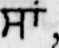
ਸਾਂ,
